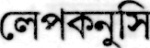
লেপকনুসি
